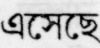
এসেছে
